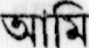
আমি
